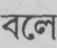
বলে
